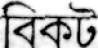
বিকট
